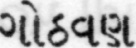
ગોઠવણ
